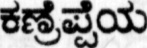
ಕಣ್ರೆಪ್ಪೆಯ
